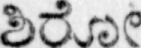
ಶಿರೋ
